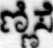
ಣ್ಣೆಸೆ
